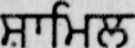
ਸ਼ਾਮਿਲ
